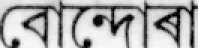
বোন্দোৰা
